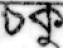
চকু
